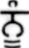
ਨੂੰ
